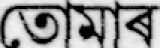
তোমাৰ
